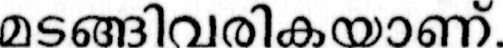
മടങ്ങിവരികയാണ്.
